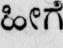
ಹೀಗೆ
